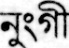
নুংগী
